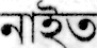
নাইত
